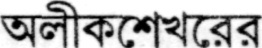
অলীকশেখরের
